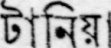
টানিয়া
